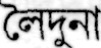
লৈদুনা
